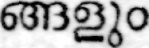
ങ്ങളും
